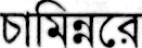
চামিন্নরে
